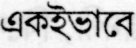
একইভাবে
